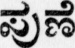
ಪುಣೆ
